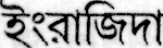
ইংরাজিদা
